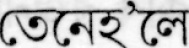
তেনেহ'লে
